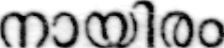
നായിരം
